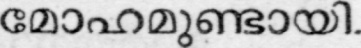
മോഹമുണ്ടായി.
